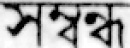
সম্বন্ধ
